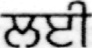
ਲਈ
